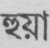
হুয়া
